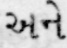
અને
